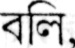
বলি,
